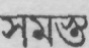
সমস্ত
